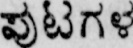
ಪುಟಗಳ
